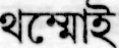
থম্মোই
